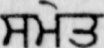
ਸਮੇਤ
